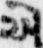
એ
